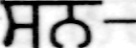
ਸਨ-
